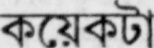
কয়েকটা
